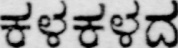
ಕಳಕಳದ
